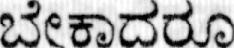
ಬೇಕಾದರೂ
